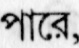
পারে,
